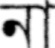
না
